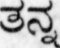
ತನ್ನ
